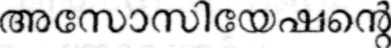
അസോസിയേഷന്റെ
